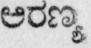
ಅರಣ್ಯ
